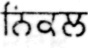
ਨਿਕਲ
